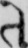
તે
